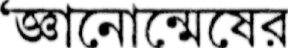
'জ্ঞানোন্মেষের
